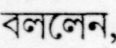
বললেন,
